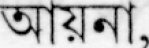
আয়না,
